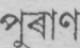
পুৰাণ
